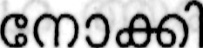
നോക്കി
